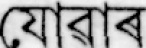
যোৱাৰ
